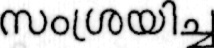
സംശ്രയിച്ച
